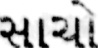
સાચો
